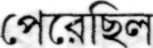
পেরেছিল
